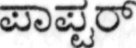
ಪಾಪ್ಟರ್
